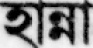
হান্না
